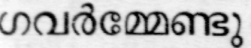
ഗവര്‍മ്മേണ്ടു
